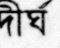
দীর্ঘ
